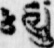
કહ્યું
